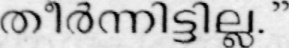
തീര്‍ന്നിട്ടില്ല."
